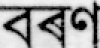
বৰণ
